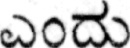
ಎಂದು
